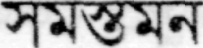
সমস্তমন
